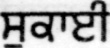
ਸੁਕਾਈ
